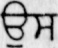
ਉਸ
